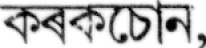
কৰকচোন,
